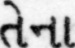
તેના
